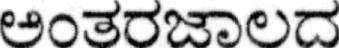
ಅಂತರಜಾಲದ
